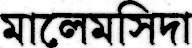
মালেমসিদা
